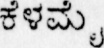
ಕೆಳಮೈ
